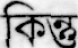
কিন্তু
